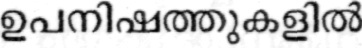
ഉപനിഷത്തുകളില്‍
